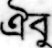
ঐবু
